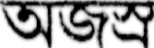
অজস্র
